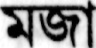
মজা
